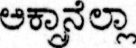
ಅಕ್ಸ್ರಾನೆಲ್ಲಾ
